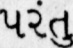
પરંતુ
